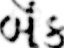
બૅંક
